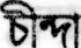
চীন্দা
